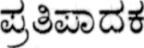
ಪ್ರತಿಪಾದಕ
